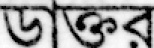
ডাক্তর
